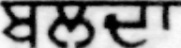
ਬਲਦਾ
